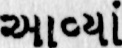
આવ્યાં
